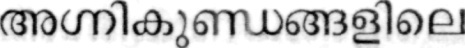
അഗ്നികുണ്ഡങ്ങളിലെ
